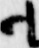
ન
